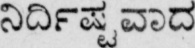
ನಿರ್ದಿಷ್ಟವಾದ
